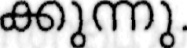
ക്കുന്നു.
